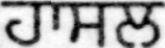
ਹਾਸਲ
